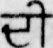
ਦੀ
